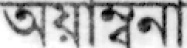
অয়াম্বনা
